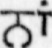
ਨਾਂ
